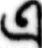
এ
